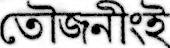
তৌজনীংই
